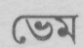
ভেম
